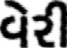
વેરી
